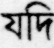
যদি
